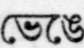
ভেঙে
